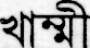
খাম্মী
